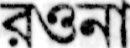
রওনা
